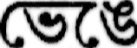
ভেঙে
